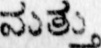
ಮತ್ತು
